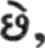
છે,
